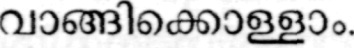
വാങ്ങിക്കൊള്ളാം.
